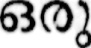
ഒരു
